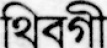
থিবগী
